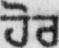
ਹੋਰ
